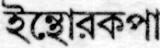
ইন্থোকপা
